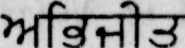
ਅਭਿਜੀਤ
